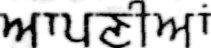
ਆਪਣੀਆਂ
